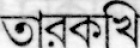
তারকখি
